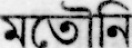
মতৌনি
